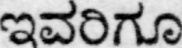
ಇವರಿಗೂ
